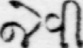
જેવી
